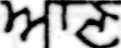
ਆਣ
